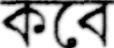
কবে
